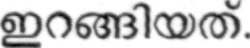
ഇറങ്ങിയത്.
